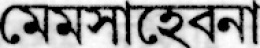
মেমসাহেবনা
